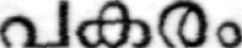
പകരം
